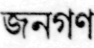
জনগণ
